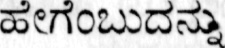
ಹೇಗೆಂಬುದನ್ನು
